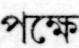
পক্ষে
